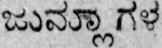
ಜುಮ್ಲಾಗಳ
